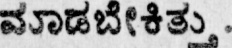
ಮಾಡಬೇಕಿತ್ತು.
